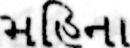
મહિના
